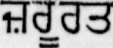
ਜ਼ਰੂਰਤ
